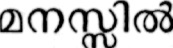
മനസ്സില്‍
